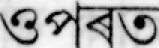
ওপৰত
